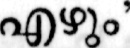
എഴും’
